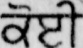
ਕੋਈ
